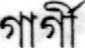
গার্গী
